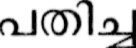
പതിച്ച
